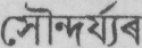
সৌন্দৰ্য্যৰ
